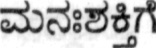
ಮನಃಶಕ್ತಿಗೆ
